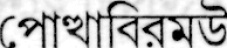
পোত্থাবিরমউ
